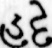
હદે
